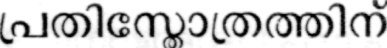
പ്രതിസ്തോത്രത്തിന്
